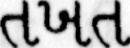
તખત
